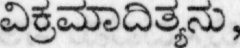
ವಿಕ್ರಮಾದಿತ್ಯನು,
